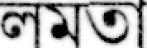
লমতা
